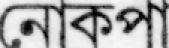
নোকপা
